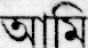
আমি
